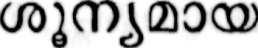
ശൂന്യമായ
